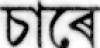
চাৰে
